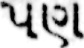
પણ
